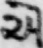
એ
